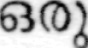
ഒരു
